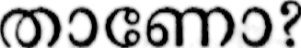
താണോ?
